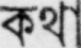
কথা
